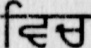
ਵਿਚ
